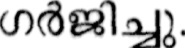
ഗര്‍ജിച്ചു.
